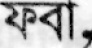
ফবা,
